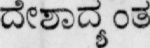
ದೇಶಾದ್ಯಂತ
